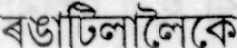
ৰঙাটিলালৈকে
